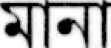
মানা
